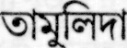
তামুলিদা
